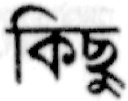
কিছু
